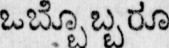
ಒಬ್ಬೊಬ್ಬರೂ
